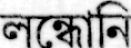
লন্ধোনি
